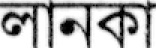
লানকা
